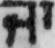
ਜਾ
